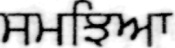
ਸਮਝਿਆ
